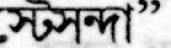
স্টেসন্দা”
